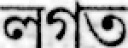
লগত
